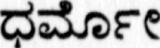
ಧರ್ಮೋ
